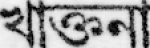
খাক্তনা
